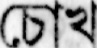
চোখ
